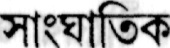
সাংঘাতিক
